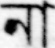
না
